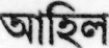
আহিল
